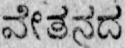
ವೇತನದ
